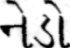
નેડો
